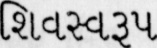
શિવસ્વરૂપ
